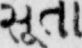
સૂતા
